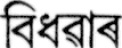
বিধৱাৰ
